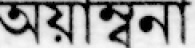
অয়াম্বনা
